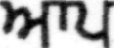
ਆਪ
